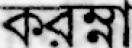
করম্না
